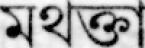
মথক্তা
